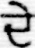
ਦੇ
